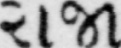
રાજા
